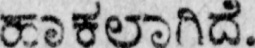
ಹಾಕಲಾಗಿದೆ.
